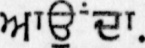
ਆਉਂਦਾ,
